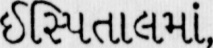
ઈસ્પિતાલમાં,
